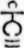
ਨੂੰ
